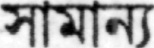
সামান্য
